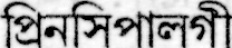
প্রিনসিপালগী
